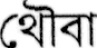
থৌবা
